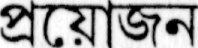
প্রয়োজন
